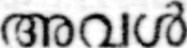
അവള്‍
